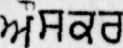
ਔਸਕਰ
